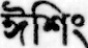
ঈশিং
